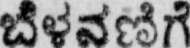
ಬೆಳವಣಿಗೆ
